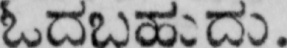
ಓದಬಹುದು.
